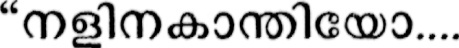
“നളിനകാന്തിയോ....
